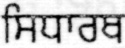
ਸਿਧਾਰਥ
